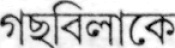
গছবিলাকে
